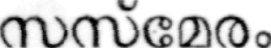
സസ്മേരം
